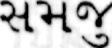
સમજુ
